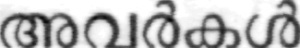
അവര്‍കള്‍
